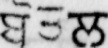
ਬੋਤਲ
